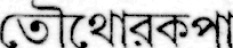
তৌথোরকপা
